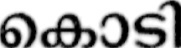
കൊടി
